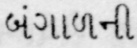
બંગાળની
